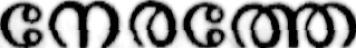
നേരത്തേ
